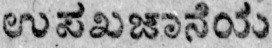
ಉಪಖಜಾನೆಯ
